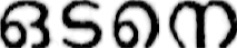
ഒടനെ
